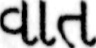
વાત
